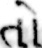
તો
